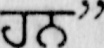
ਹਨ''
